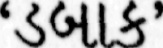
'ડબાક'
